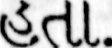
હતા.
